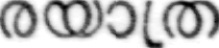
രയാത്ര
